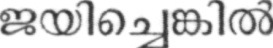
ജയിച്ചെങ്കില്‍
